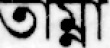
তাম্না
